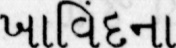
ખાવિંદના
